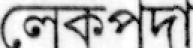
লেকপদা
